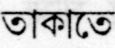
তাকাতে
